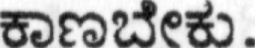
ಕಾಣಬೇಕು.
